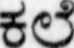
ಕಲೆ
